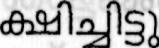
ക്ഷിച്ചിട്ടു
